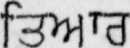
ਤਿਆਰ
